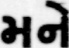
મને
